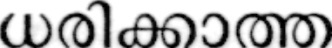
ധരിക്കാത്ത
